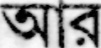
আর
